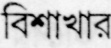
বিশাখার
